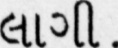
લાગી.
